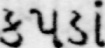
કપડાં
